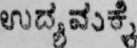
ಉದ್ಯಮಕ್ಕೆ
